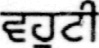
ਵਹੁਟੀ
